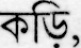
কড়ি,
